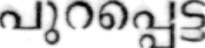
പുറപ്പെട്ട
